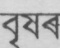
বৃষৰ
